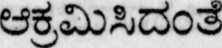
ಆಕ್ರಮಿಸಿದಂತೆ
